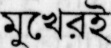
মুখেরই
